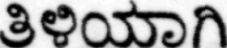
ತಿಳಿಯಾಗಿ
